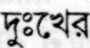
দুঃখের
